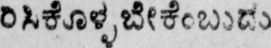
ರಿಸಿಕೊಳ್ಳಬೇಕೆಂಬುದು
